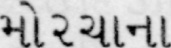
મોરચાના
